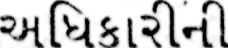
અધિકારીની
